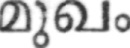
മുഖം
